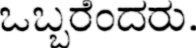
ಒಬ್ಬರೆಂದರು.
